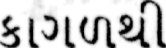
કાગળથી
